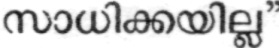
സാധിക്കയില്ല”
